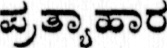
ಪ್ರತ್ಯಾಹಾರ
